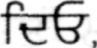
ਦਿਓ,
